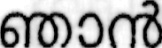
ഞാന്‍
